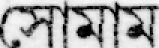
সোমাম
